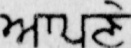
ਆਪਣੇ
